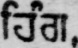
ਹਿੰਗ,
